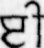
ਈ
